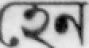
হেন
